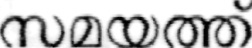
സമയത്ത്
